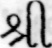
શ્રી
